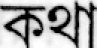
কথা
